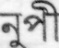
নুপী
